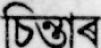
চিন্তাৰ
